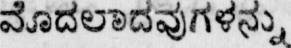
ಮೊದಲಾದವುಗಳನ್ನು
